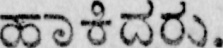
ಹಾಕಿದರು.
